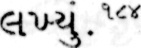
લખ્યું.૧૮૪
